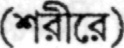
(শরীরে)
